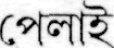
পেলাই
